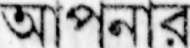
আপনার
